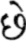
છે
